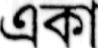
একা
